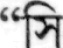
"সি
